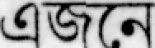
এজনে
